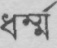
ধৰ্ম্ম
